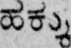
ಹಕ್ಕು
